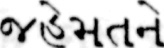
જહેમતને
